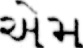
એમ
